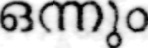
ഒന്നും
